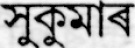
সুকুমাৰ
